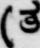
(ತ
